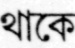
থাকে
